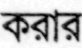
করার
